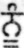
ਨੂੰ
